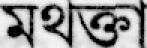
মথক্তা
